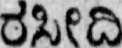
ರಸೀದಿ
